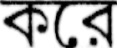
করে
